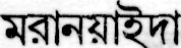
মরানয়াইদা
